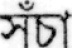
সঁচা
